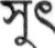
সুৎ
